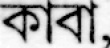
কাবা,
